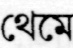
থেমে
